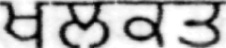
ਖਲਕਤ
